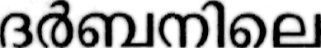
ദര്‍ബനിലെ
